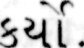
કર્યો.
